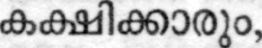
കക്ഷിക്കാരും,
